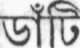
ডাঁটি
